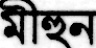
মীহুন
